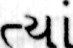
ત્યાં
